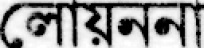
লোয়ননা
